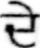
ਦੇ
